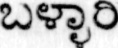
ಬಳ್ಳಾರಿ
